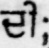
ਦੀ;
